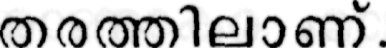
തരത്തിലാണ്.
